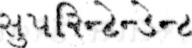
સુપરિન્ટેન્ડેન્ટ
